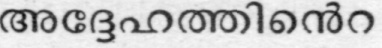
അദ്ദേഹത്തിന്റെ
